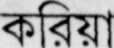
করিয়া
